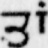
ਤਾਂ
